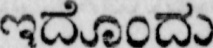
ಇದೊಂದು
